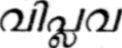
വിപ്ലവ
